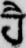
ਹੈ
